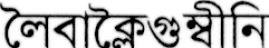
লৈবাক্লৈগুম্বীনি
